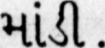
માંડી.
